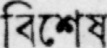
বিশেষ
